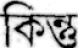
কিন্তু
